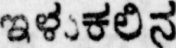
ಇಳುಕಲಿನ
